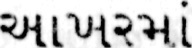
આખરમાં
